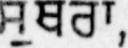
ਸੁਥਰਾ,
